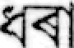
ধৰা
